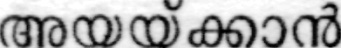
അയയ്ക്കാന്‍
